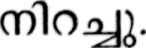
നിറച്ചു.
